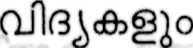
വിദ്യകളും
